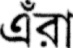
এঁরা
